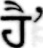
ਹੈ'
